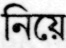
নিয়ে
